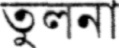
তুলনা
